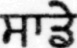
ਸਾਡੇ
